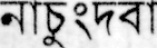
নাচুংদবা
